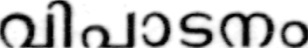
വിപാടനം
